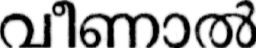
വീണാല്‍
